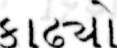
કાઢ્યો
